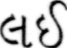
લઈ
